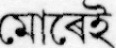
মোৰেই
